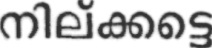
നില്ക്കട്ടെ
